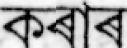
কৰাৰ
